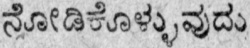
ನೋಡಿಕೊಳ್ಳುವುದು
